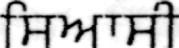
ਸਿਆਸੀ
